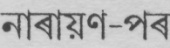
নাৰায়ণ-পৰ
